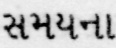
સમયના
